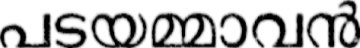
പടയമ്മാവന്‍
